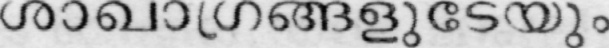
ശാഖാഗ്രങ്ങളുടേയും
